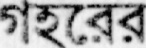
গহরের
